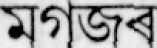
মগজৰ
